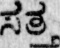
ಸತ್ತ
